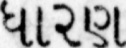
ધારણ
